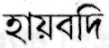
হায়বদি
